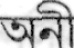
অনী
